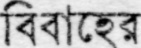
বিবাহের
